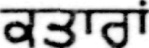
ਕਤਾਰਾਂ
